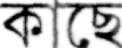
কাছে
